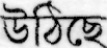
উঠিছে
